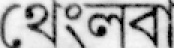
থেংলবা
